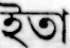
ইতা
